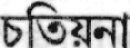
চতিয়না
